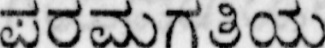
ಪರಮಗತಿಯ
